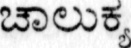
ಚಾಲುಕ್ಯ
